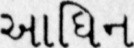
આધિન
